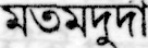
মতমদুদা
